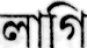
লাগি
